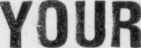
YOUR
